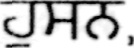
ਹੁਸਨ,
